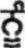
ਨੂੰ
